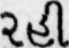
રહી
